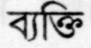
ব্যক্তি
